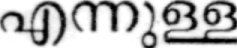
എന്നുള്ള
